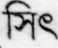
সিৎ
